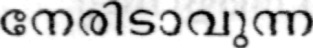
നേരിടാവുന്ന
